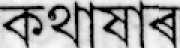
কথাষাৰ
